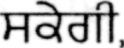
ਸਕੇਗੀ,
